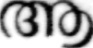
ആ
